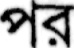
পর
